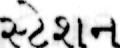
સ્ટેશન
